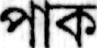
পাক
